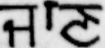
ਜਾਣ
